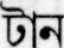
টান
